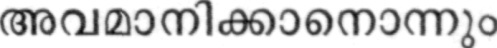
അവമാനിക്കാനൊന്നും
